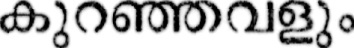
കുറഞ്ഞവളും
